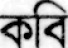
কবি
